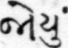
જોયું
